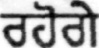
ਰਹੋਗੇ
